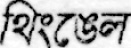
থিংঙেল
